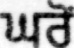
ਘਰੋਂ
